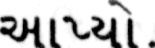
આપ્યો.
